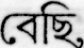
বেছি,
